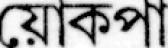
য়োকপা
